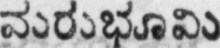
ಮರುಭೂಮಿ
